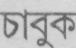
চাবুক
